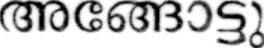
അങ്ങോട്ടു
